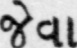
જેવા
